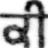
ਕੀ
